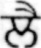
ਲੈ
